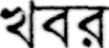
খবর
